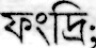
ফংদ্রি;
